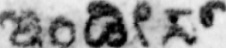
ಇಂಡೀಸ್
